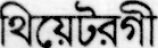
থিয়েটরগী
